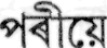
পৰীয়ে
